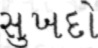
સુખદો
